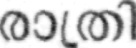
രാത്രി
